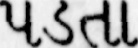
પડતા
